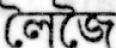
লৈজৈ
